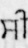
ਸੀ
